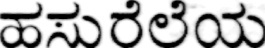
ಹಸುರೆಲೆಯ
